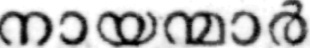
നായന്മാര്‍
